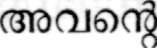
അവന്റെ
